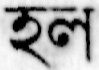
হল
